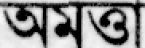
অমত্তা
